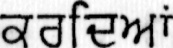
ਕਰਦਿਆਂ
